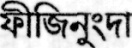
ফীজিনুংদা
